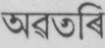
অৱতৰি
